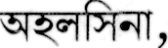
অহলসিনা,
